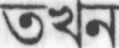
তখন
